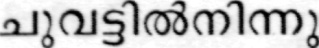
ചുവട്ടില്‍നിന്നു
